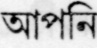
আপনি
